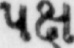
પક્ષ
